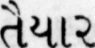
તૈયાર
